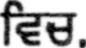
ਵਿਚ,
